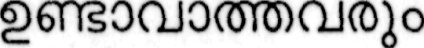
ഉണ്ടാവാത്തവരും
